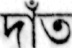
দাঁত
